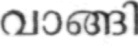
വാങ്ങി
